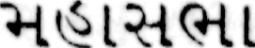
મહાસભા
